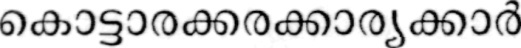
കൊട്ടാരക്കരക്കാര്യക്കാര്‍
